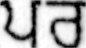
ਪਰ
